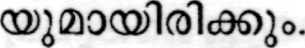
യുമായിരിക്കും.
